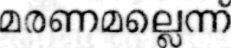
മരണമല്ലെന്ന്
